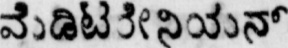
ಮೆಡಿಟರೇನಿಯನ್
